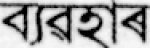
ব্যৱহাৰ
